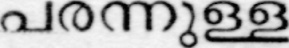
പരന്നുള്ള
